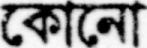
কোনো
